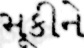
મૂકીને
